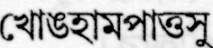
খোঙহামপাত্তসু
